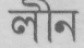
লীন
